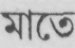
মাতে
